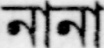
নানা
